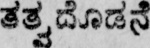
ತತ್ವದೊಡನೆ
